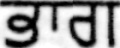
ਭਾਗ
